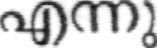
എന്നു
